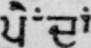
ਪੈਂਦਾਂ
